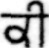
ਕੀ
